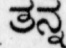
ತನ್ನ
